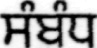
ਸੰਬੰਧ
